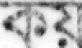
কয়
